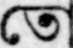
তো
